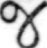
જ
